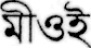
মীওই
